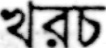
খরচ
